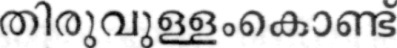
തിരുവുള്ളംകൊണ്ട്
